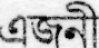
এজনী
